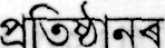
প্রতিষ্ঠানৰ
